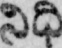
ನಿಧಿ
